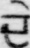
ਦੇ
